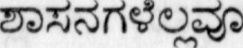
ಶಾಸನಗಳೆಲ್ಲವೂ
